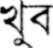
খুব
